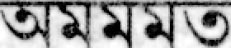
অমমমত
